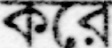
করে
